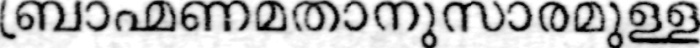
ബ്രാഹ്മണമതാനുസാരമുള്ള
